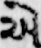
એ
